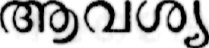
ആവശ്യ
